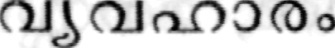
വ്യവഹാരം
